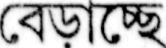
বেড়াচ্ছে
